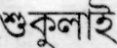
শুকুলাই
